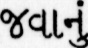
જવાનું
